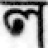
ল
